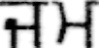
ਜਮ
